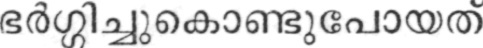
ഭര്‍ഗ്ഗിച്ചുകൊണ്ടുപോയത്
